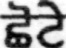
ਛੋਟੇ
